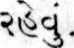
રહેવું.
